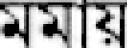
মমায়
